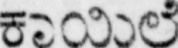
ಕಾಯಿಲೆ
